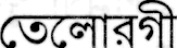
তেলোরগী
